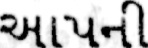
આપની
